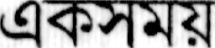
একসময়
